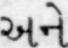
અને
